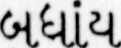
બધાંય
